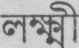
লক্ষ্মী
